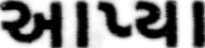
આપ્યા
